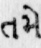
તમે
